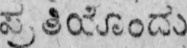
ಪ್ರತಿಯೊಂದು
